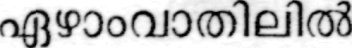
ഏഴാംവാതിലില്‍
